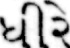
ધીરે
